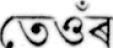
তেওঁৰ
